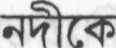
নদীকে
